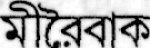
মীরৈবাক
